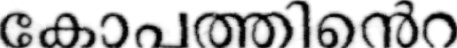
കോപത്തിന്റെ
